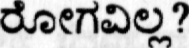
ರೋಗವಿಲ್ಲ?
